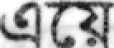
এয়ে
